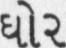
ઘોર
